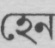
হেন
